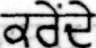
ਕਰੇਂਦੇ
